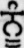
ਨੂੰ
